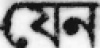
যেন
